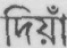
দিয়াঁ
